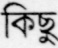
কিছু
